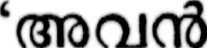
‘അവന്‍
